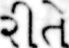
રીતે
